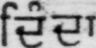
ਦਿੰਦਾ
